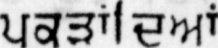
ਪਕੜਾਂਦਿਆਂ
